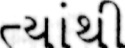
ત્યાંથી
